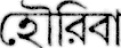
হৌরিবা
